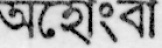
অহোংবা
